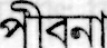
পীবনা
